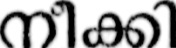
നീക്കി
